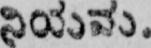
ನಿಯಮ.
